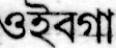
ওইবগা
